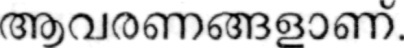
ആവരണങ്ങളാണ്.
